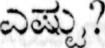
ಎಷ್ಟು?
